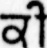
ਕੀ
